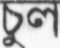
চুল
